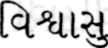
વિશ્વાસુ
